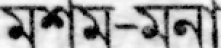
মশম-মনা
